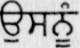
ਉਸਨੂੰ
